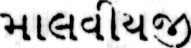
માલવીયજી
